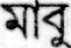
মাবু
